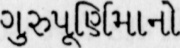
ગુરુપૂર્ણિમાનો
